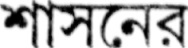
শাসনের
